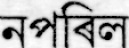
নপৰিল
